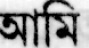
আমি
